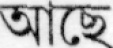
আছে
